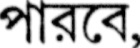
পারবে,
